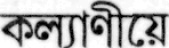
কল্যাণীয়ে
